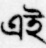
এই
